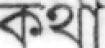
কথা
